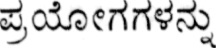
ಪ್ರಯೋಗಗಳನ್ನು
